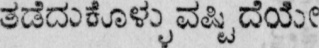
ತದೆದುಕೊಳ್ಳುವಷ್ಟಿದೆಯೇ
